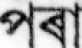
পৰা
